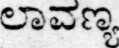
ಲಾವಣ್ಯ
